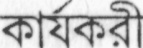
কার্যকরী
